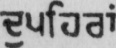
ਦੁਪਹਿਰਾਂ
